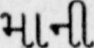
માની
